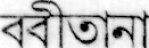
ববীতানা
